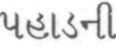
પહાડની
